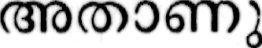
അതാണു
